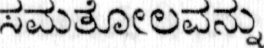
ಸಮತೋಲವನ್ನು
